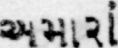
અમારાં
